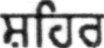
ਸ਼ਹਿਰ
